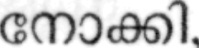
നോക്കി,
